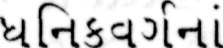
ધનિકવર્ગનાં
